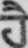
ਹੈ
